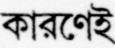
কারণেই
